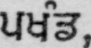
ਪਖੰਡ,
